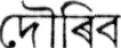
দৌৰিব
